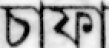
চাফা
